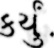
કર્યું.
